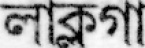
লাক্লগা
